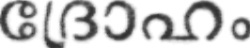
ദ്രോഹം
